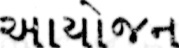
આયોજન
